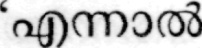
'എന്നാല്‍
